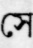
সে
